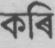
কৰি
